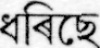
ধৰিছে
